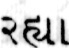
રહ્યા
